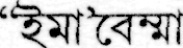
“ইমা’বেম্মা
